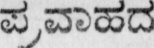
ಪ್ರವಾಹದ
